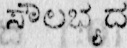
ಸೌಲಭ್ಯದ
